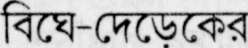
বিঘে-দেড়েকের
